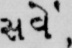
સર્વે,
